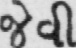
જેવી
